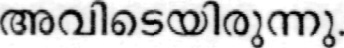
അവിടെയിരുന്നു.
